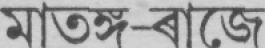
মাতঙ্গ-ৰাজে
